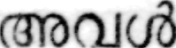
അവള്‍
